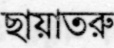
ছায়াতরু
